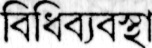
বিধিব্যবস্থা
